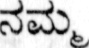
ನಮ್ಮ
